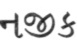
નજીક
